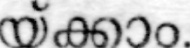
യ്ക്കാം.
